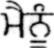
ਮੈਨੂੰ
